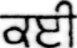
ਕਈ
